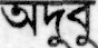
অবুদু
